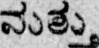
ಮತ್ತು
